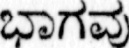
ಭಾಗವು
